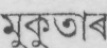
মুকুতাৰ
